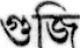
গুজি
